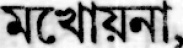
মখোয়না,
